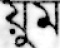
য়ুম
